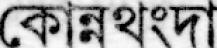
কোন্নথংদা
